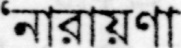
‘নারায়ণা
